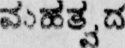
ಮಹತ್ವದ
